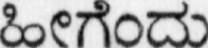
ಹೀಗೆಂದು
